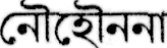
নৌহৌননা
